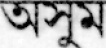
অসুম
